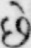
છે
